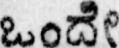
ಒಂದೇ
